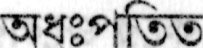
অধঃপতিত
